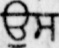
ਉਸ
